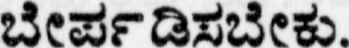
ಬೇರ್ಪಡಿಸಬೇಕು.
